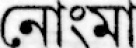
নোংমা
